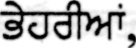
ਭੇਹਰੀਆਂ,
